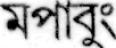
মপাবুং
